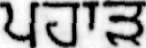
ਪਹਾੜ
